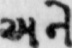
અને
